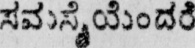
ಸಮಸ್ಯೆಯೆಂದರೆ
